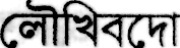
লৌখিবদো
